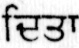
ਦਿਤਾ
